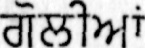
ਗੋਲੀਆਂ
